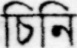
চিনি
